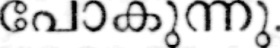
പോകുന്നു.
